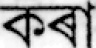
কৰা
